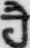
ਹੈ
